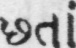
છતાં
